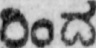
ರಿಂದ
